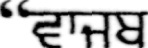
''ਵਾਜਬ
